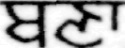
ਬਣਾ
